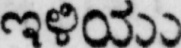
ಇಳಿಯು
